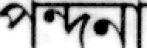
পন্দনা
